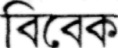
বিবেক
